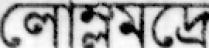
লোম্লমদ্রে
